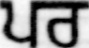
ਪਰ
